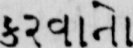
કરવાનો
